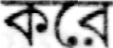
করে
